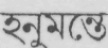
হনুমন্তে
